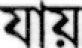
যায়
